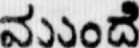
ಮುಂದೆ
